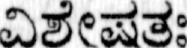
ವಿಶೇಷತಃ
